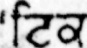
'ਟਿਕ
